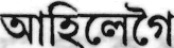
আহিলেগৈ
